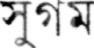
সুগম
